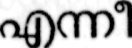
എന്നീ
